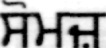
ਸੋਮਜ਼
